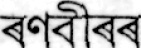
ৰণবীৰৰ
